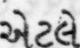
એટલે
